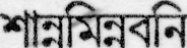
শান্নমিন্নবনি
